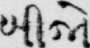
બીજો
